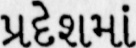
પ્રદેશમાં
